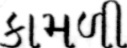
કામળી
